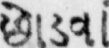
છોડવાં
